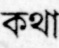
কথা
